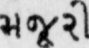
મજૂરી
